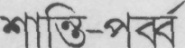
শান্তি-পৰ্ব্ব
